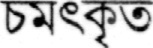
চমৎকৃত
